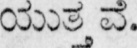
ಯುತ್ತವೆ.
